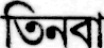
তিনবা
